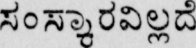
ಸಂಸ್ಕಾರವಿಲ್ಲದೆ
